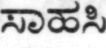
ಸಾಹಸಿ
